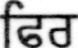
ਫਿਰ
